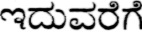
ಇದುವರೆಗೆ
